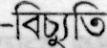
-বিচ্যুতি
